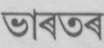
ভাৰতৰ
